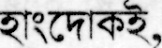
হাংদোকই,
